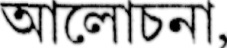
আলোচনা,
